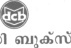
ബുക്സ്
